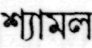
শ্যামল
